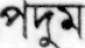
পদুম
